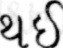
થઈ
